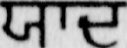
ਯਾਦ
